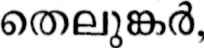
തെലുങ്കര്‍,
